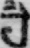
ਹੈ
